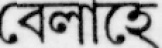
বেলাহে
